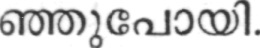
ഞ്ഞുപോയി.
